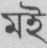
মই
